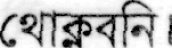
থোক্নবনি।
